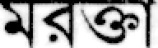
মরক্তা
